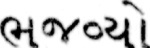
ભજવ્યો
